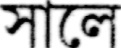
সালে
